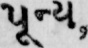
પૂન્ય,
